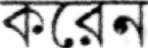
করেন
